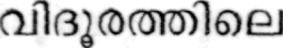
വിദൂരത്തിലെ
